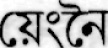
য়েংনৈ
